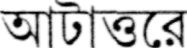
আটাত্তরে
